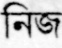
নিজ
